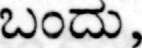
ಬಂದು,
